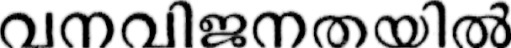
വനവിജനതയില്‍
